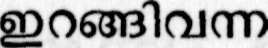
ഇറങ്ങിവന്ന
